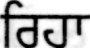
ਰਿਹਾ
